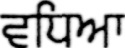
ਵਧਿਆ
